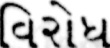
વિરોધ
